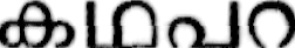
കഥപറ
